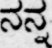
ನನ್ನ
